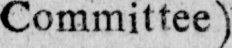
Committee)
